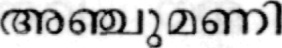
അഞ്ചുമണി
